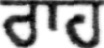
ਰਾਹ
